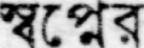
স্বপ্নের
